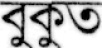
বুকুত
